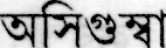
অসিগুম্বা
